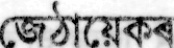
জেঠায়েকৰ
